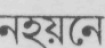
নহয়নে
